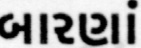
બારણાં
